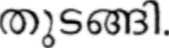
തുടങ്ങി.
